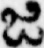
ಜಿ
